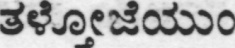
ತಳ್ತೋಜೆಯುಂ
